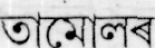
তামোলৰ
